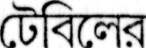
টেবিলের
